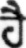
ਹੈ
